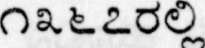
೧೩೬೭ರಲ್ಲಿ
